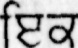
ਇਕ
